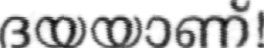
ദയയാണ്!
